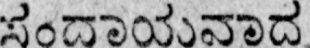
ಸಂದಾಯವಾದ
